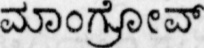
ಮ್ಯಾಂಗ್ರೋವ್
